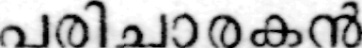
പരിചാരകന്‍
